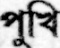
পুখি
